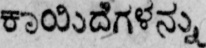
ಕಾಯಿದೆಗಳನ್ನು
